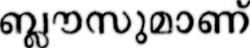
ബ്ലൌസുമാണ്
